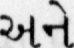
અને
